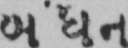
બંધન
